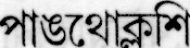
পাঙথোক্লশি
